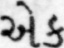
એક
